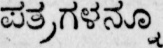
ಪತ್ರಗಳನ್ನೂ
